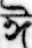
ঈ
